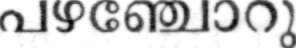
പഴഞ്ചോറു
